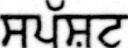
ਸਪੱਸ਼ਟ
